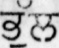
ਭੁੱਲ
